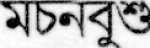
মচনবুশু
